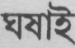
ঘষাই
